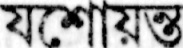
যশোয়ন্ত
